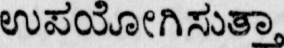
ಉಪಯೋಗಿಸುತ್ತಾ
